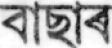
বাছাৰ
